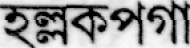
হল্লকপগা
